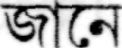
জানে
